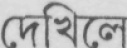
দেখিলে
